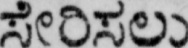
ಸೇರಿಸಲು
